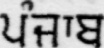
ਪੰਜਾਬ
